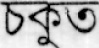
চকুত
